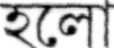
হলো
